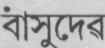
বাসুদেৱ
